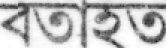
বতাহত
